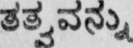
ತತ್ವವನ್ನು
